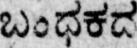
ಬಂಧಕದ
